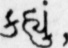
કહ્યું,
